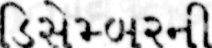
ડિસેમ્બરની
